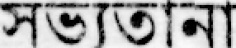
সভ্যতানা
